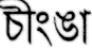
চীংঙা
